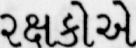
રક્ષકોએ
